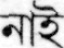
নাই
